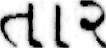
તાર
